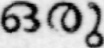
ഒരു
